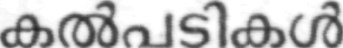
കല്‍പടികള്‍
